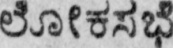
ಲೋಕಸಭೆ
